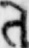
તે
